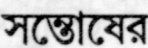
সন্তোষের
